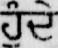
ਹੁੰਦੇ
